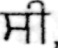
ਸੀ,
